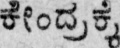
ಕೇಂದ್ರಕ್ಕೆ
